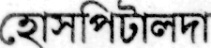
হোসপিটালদা
